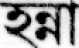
হন্না
